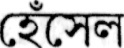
হেঁসেল
